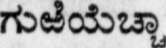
ಗುಱಯೆಚ್ಚಾ
